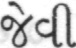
જેવી
